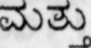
ಮತ್ತು
